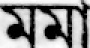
মমা
